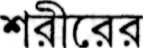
শরীরের
